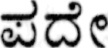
ಪದೇ
